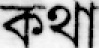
কথা
